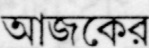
আজকের
